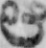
ಆ
